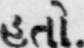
હતો.
